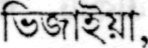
ভিজাইয়া,
